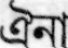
ঐনা
